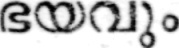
ഭയവും
